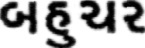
બહુચર
